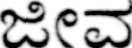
ಜೀವ
